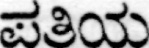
ಪತಿಯ
